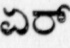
ಏರ್
